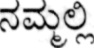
ನಮ್ಮಲ್ಲಿ
